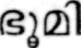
ഭൂമി
